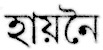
হায়নৈ
